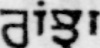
ਰਾਂਝਾ
